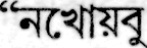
“নখোয়বু
